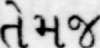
તેમજ
